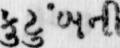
કુટુંબની
